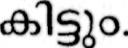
കിട്ടും.
